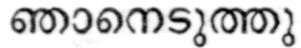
ഞാനെടുത്തു
